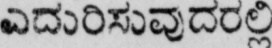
ಎದುರಿಸುವುದರಲ್ಲಿ
